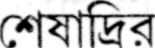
শেষাদ্রির
